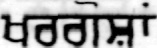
ਖਰਗੋਸ਼ਾਂ
